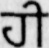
ਹੀ
